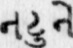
નટુને
